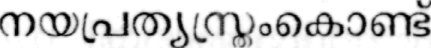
നയപ്രത്യസ്ത്രംകൊണ്ട്
